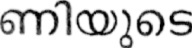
ണിയുടെ
